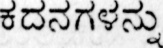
ಕದನಗಳನ್ನು
